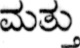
ಮತ್ತು
